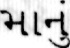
માનું
